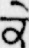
ਕੇ
